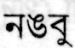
নঙবু
